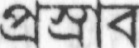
প্রস্রাব
